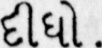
દીધો.
